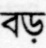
বড়
